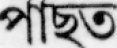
পাছত
